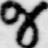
જ
